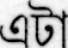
এটা
